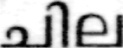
ചില
